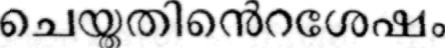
ചെയ്തതിന്റെശേഷം
